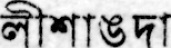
লীশাঙদা
